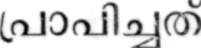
പ്രാപിച്ചത്
